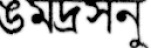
ঙমদ্রসনু
